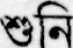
শুনি
